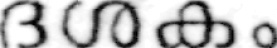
ദശകം
